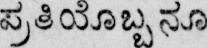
ಪ್ರತಿಯೊಬ್ಬನೂ
